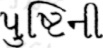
પુષ્ટિની
